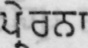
ਪ੍ਰੇਰਨਾ
